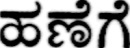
ಹಣೆಗೆ
